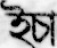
ইচা
